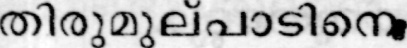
തിരുമുല്പാടിനെ
